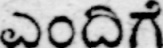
ಎಂದಿಗೆ
